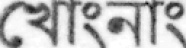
খোংনাং
